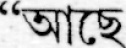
"আছে
